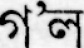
গ'ল
